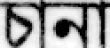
চানা
